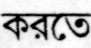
করতে
